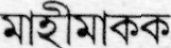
মাহীমাকক
